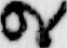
જ
